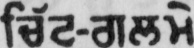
ਚਿੱਟ-ਗਲਮੇ
